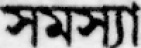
সমস্যা
